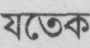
যতেক
